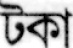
টকা
